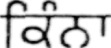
ਕਿੰਨਾ
